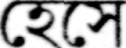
হেসে
